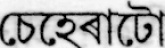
চেহেৰাটো
